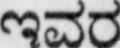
ಇವರ
